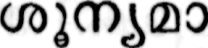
ശൂന്യമാ
